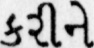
કરીને
